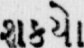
શક્યો
